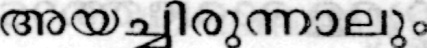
അയച്ചിരുന്നാലും
